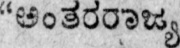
“ಅಂತರರಾಜ್ಯ
